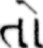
તો
